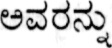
ಅವರನ್ನು
